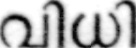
വിധി
